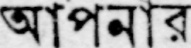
আপনার
